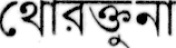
থোরক্তুনা
